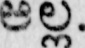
ಅಲ್ಲ.
